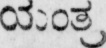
ಯಂತ್ರ
